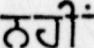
ਨਹੀਂ
